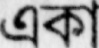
একা
